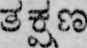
ತಕ್ಷಣ
